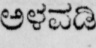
ಅಳವಡಿ
